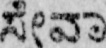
ಸೇವಾ
